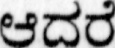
ಆದರೆ
